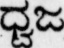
ಧ್ವಜ
